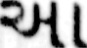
આ
